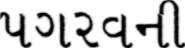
પગરવની
